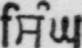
ਸਿੰਘ
